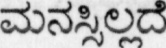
ಮನಸ್ಸಿಲ್ಲದೆ
